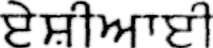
ਏਸ਼ੀਆਈ
